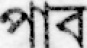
পাব
